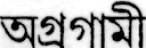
অগ্ৰগামী
